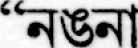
“নঙনা
